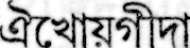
ঐখোয়গীদা
